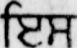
ਇਸ
